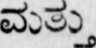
ಮತ್ತು
